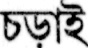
চড়াই
